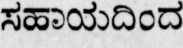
ಸಹಾಯದಿಂದ
